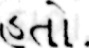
હતો.
